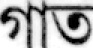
গাত
